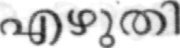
എഴുതി
